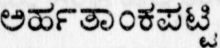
ಅರ್ಹತಾಂಕಪಟ್ಟಿ
